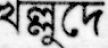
খল্লুদে
